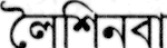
লৈশিনবা
